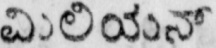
ಮಿಲಿಯನ್
